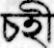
চহী
